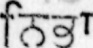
ਨਿਭਾ
